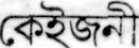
কেইজনী
